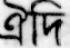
ঐদি
